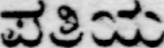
ಪತಿಯ
